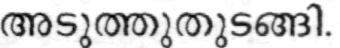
അടുത്തുതുടങ്ങി.
